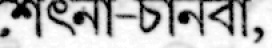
শেৎনা-চানবা,
